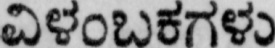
ವಿಳಂಬಕಗಳು
